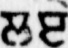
ਲਏ
